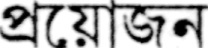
প্রয়োজন
